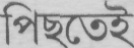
পিছতেই
